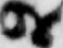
જ
